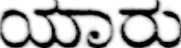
ಯಾರು
